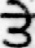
ਤੇ
